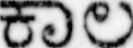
ಕಾಲ
